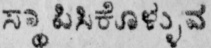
ಸ್ಥಾಪಿಸಿಕೊಳ್ಳುವ
